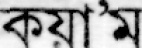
কয়া’ম
